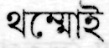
থম্মোই
